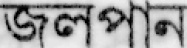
জলপান
